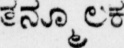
ತನ್ಮೂಲಕ
